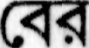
বের
